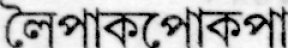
লৈপাকপোকপা
